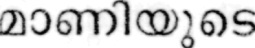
മാണിയുടെ
